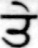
ਤੇ
